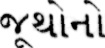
જૂથોનો
